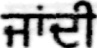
ਜਾਂਦੀ
